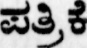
ಪತ್ರಿಕೆ
